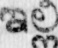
ಇಲ್ಲಿ
